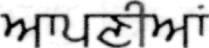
ਆਪਣੀਆਂ
